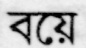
বয়ে
